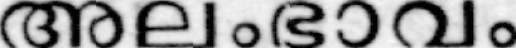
അലംഭാവം
